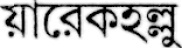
য়ারেকহল্লু
